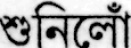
শুনিলোঁ
